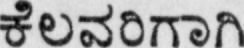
ಕೆಲವರಿಗಾಗಿ
